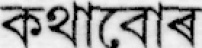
কথাবোৰ
